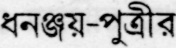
ধনঞ্জয়-পুত্রীর
